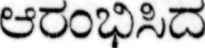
ಆರಂಭಿಸಿದ
